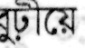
বুঢ়ীয়ে
